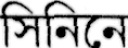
সিনিনে
